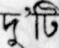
দু’টি
